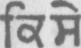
ਕਿਸੇ
